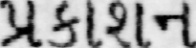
પ્રકાશન
